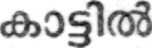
കാട്ടില്‍
